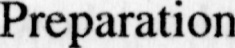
Preparation
